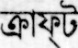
ক্রাফট
